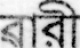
ৱারী
